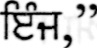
ਇੰਜ,''
